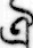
ঐ
